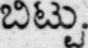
ಬಿಟ್ಟು.
